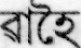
ৱাহৈ
